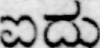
ಐದು
